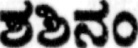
ಶಶಿನಂ
